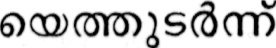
യെത്തുടര്‍ന്ന്
